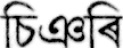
চিঞৰি
